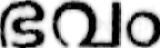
ഭവം
